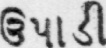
ઉપાડી
